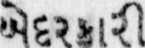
બેદરકારી
